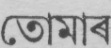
তোমাৰ
